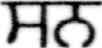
ਸਨ
